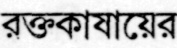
রক্তকাষায়ের
